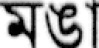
মঙা
